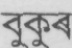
বুকুৰ
